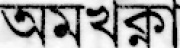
অমখক্না
